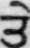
ਤੇ
